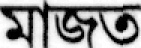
মাজত
